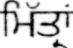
ਮਿੱਤ੍ਰਾਂ
